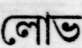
লোভ
